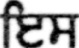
ਇਸ
